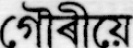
গৌৰীয়ে
